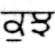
ਕੁਝ
